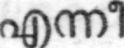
എന്നീ
